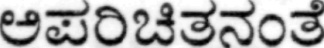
ಅಪರಿಚಿತನಂತೆ
